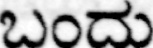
ಬಂದು
